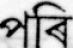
পৰি
